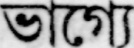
ভাগ্যে
